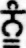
ਨੂੰ
